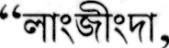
“লাংজীংদা,
